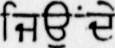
ਜਿਉਂਦੇ
